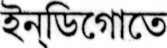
ইন্ডিগোতে
